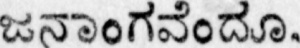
ಜನಾಂಗವೆಂದೂ.
